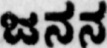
ಜನನ
